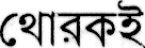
থোরকই
